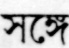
সঙ্গে
